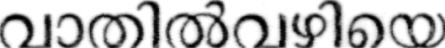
വാതില്‍വഴിയെ
